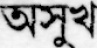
অসুখ
